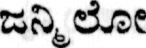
ಜನ್ಮಿಲೋ
